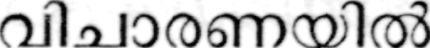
വിചാരണയില്‍
